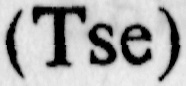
(Tse)
